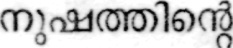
നുഷത്തിന്റെ
